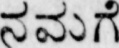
ನಮಗೆ
